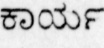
ಕಾರ್ಯ
